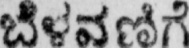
ಬೆಳವಣಿಗೆ
